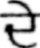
ਦੇ
